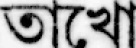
তাখো
